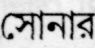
সোনার
